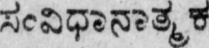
ಸಂವಿಧಾನಾತ್ಮಕ
